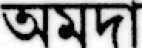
অমদা
